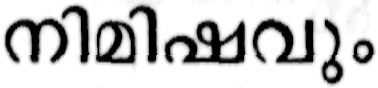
നിമിഷവും
